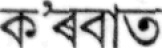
ক'ৰবাত
